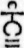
ਨੂੰ
